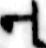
ન
